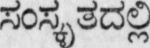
ಸಂಸ್ಕೃತದಲ್ಲಿ
